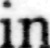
in
